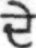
ਦੇ
